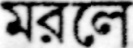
মরলে
